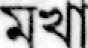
মখা
